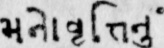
મનોવૃત્તિનું
